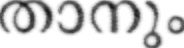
താനും
